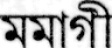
মমাগী
